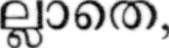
ല്ലാതെ,
